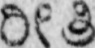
ರೀತಿ
